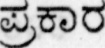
ಪ್ರಕಾರ
